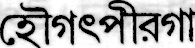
হৌগৎপীরগা
